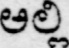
ಅಲ್ಲಿ
